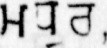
ਮਧੁਰ,
